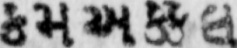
કમઅક્કલ
